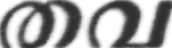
തവ
